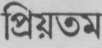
প্ৰিয়তম
